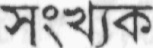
সংখ্যক
